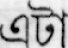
এটা
